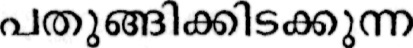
പതുങ്ങിക്കിടക്കുന്ന
